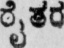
ರೈತರ
